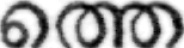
ത്തെ
